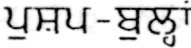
ਪੁਸ਼ਪ-ਬੁਲ੍ਹਾਂ
